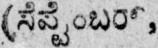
(ಸೆಪ್ಟೆಂಬರ್,
